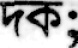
দক;
